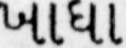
ખાધા
